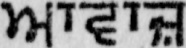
ਆਵਾਜ਼
